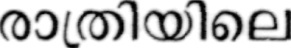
രാത്രിയിലെ
